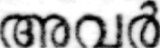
അവര്‍
